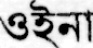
ওইনা
